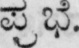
ಪ್ರಭೆ.
